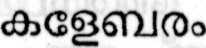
കളേബരം
